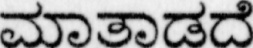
ಮಾತಾಡದೆ
